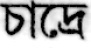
চাদ্রে
